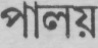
পালয়
